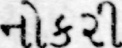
નોકરી
